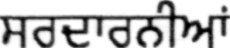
ਸਰਦਾਰਨੀਆਂ
